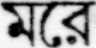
মরে
